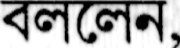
বললেন,
